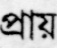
প্রায়
